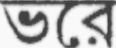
ভরে
